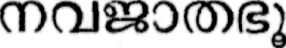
നവജാതഭൂ
